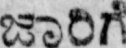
ಜಾರಿಗೆ
